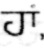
ਹਾਂ,
